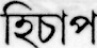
হিচাপ
